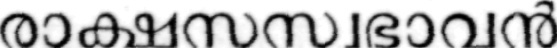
രാക്ഷസസ്വഭാവന്‍
